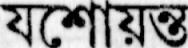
যশোয়ন্ত
